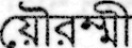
য়ৌরম্মী
